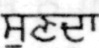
ਸੁਣਦਾ
